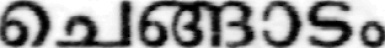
ചെങ്ങാടം
